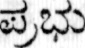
ಪ್ರಭು
